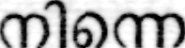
നിന്നെ
